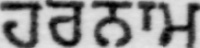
ਹਰਨਾਮ
